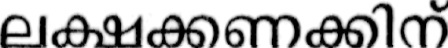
ലക്ഷക്കണക്കിന്
